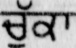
ਚੁੱਕਾ
